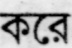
করে
